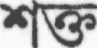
শক্ত
